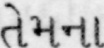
તેમના
